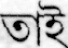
তাই
